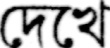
দেখে
